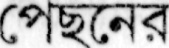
পেছনের
